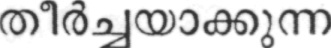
തീര്‍ച്ചയാക്കുന്ന
